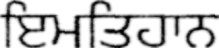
ਇਮਤਿਹਾਨ
